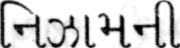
નિઝામની
